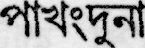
পাখংদুনা
